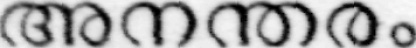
അനന്തരം
